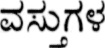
ವಸ್ತುಗಳ
